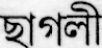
ছাগলী
